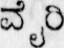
ವೈರಿ
